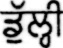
ਡੁੱਲ੍ਹੀ
